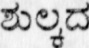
ಶುಲ್ಕದ
